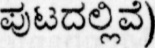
ಪುಟದಲ್ಲಿವೆ)
